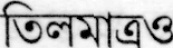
তিলমাত্ৰও
